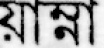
য়াম্না
